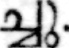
ച്ചു.
